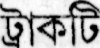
ট্রাকটি
